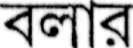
বলার
